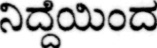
ನಿದ್ದೆಯಿಂದ
